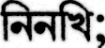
নিনখি;
